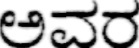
ಅವರ
